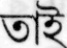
তাই
